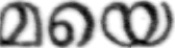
മയെ
